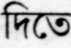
দিতে
